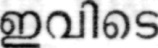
ഇവിടെ
